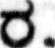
ರ.
